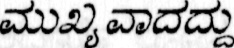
ಮುಖ್ಯವಾದದ್ದು
